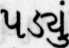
પડ્યું
